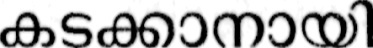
കടക്കാനായി
